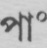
পা
